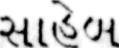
સાહેબ
